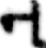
ન
